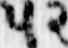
પરંતુ
